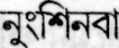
নুংশিনবা
